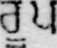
ਰੂਪ
